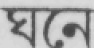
ঘনে
